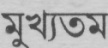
মুখ্যতম
